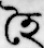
হৈ
